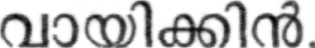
വായിക്കിന്‍.
